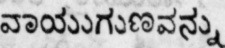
ವಾಯುಗುಣವನ್ನು
